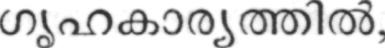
ഗൃഹകാര്യത്തില്‍,
